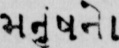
મનુષનો
